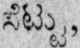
ಸೆಟ್ಟು,
